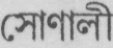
সোণালী
